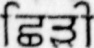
ਛਿੜੀ
